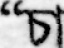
“চা
